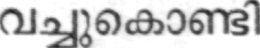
വച്ചുകൊണ്ടി
